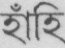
হাঁহি
